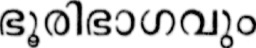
ഭൂരിഭാഗവും
